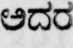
ಅದರ
